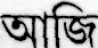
আজি
